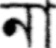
না
